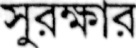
সুরক্ষার
